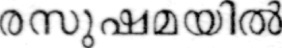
രസുഷമയില്‍
